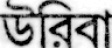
উরিবা
